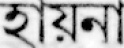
হায়না
